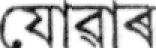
যোৱাৰ
